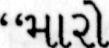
"મારો
